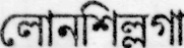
লোনশিল্লগা
